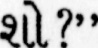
શો?"
